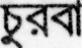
চুরবা
